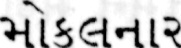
મોકલનાર
